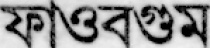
ফাওবগুম
